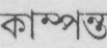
কাম্পন্ত
